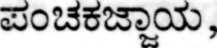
ಪಂಚಕಜ್ಜಾಯ,
